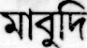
মাবুদি
